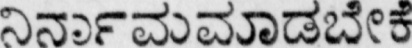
ನಿರ್ನಾಮಮಾಡಬೇಕೆ
